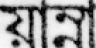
য়াম্না
